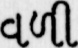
વળી
